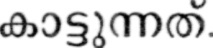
കാട്ടുന്നത്.
